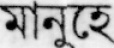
মানুহে
